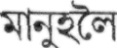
মানুহলৈ
